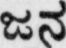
ಜನ
